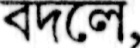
বদলে,
